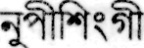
নুপীশিংগী
